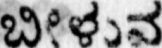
ಬೀಳುವ
